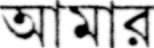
আমার
